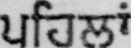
ਪਹਿਲਾਂ
